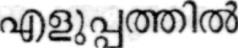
എളുപ്പത്തില്‍
